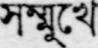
সম্মুখে
